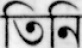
তিনি
